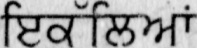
ਇਕੱਲਿਆਂ
